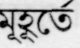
মূহূর্তে
